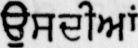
ਉਸਦੀਆਂ
